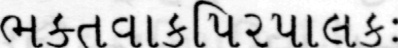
ભક્તવાકપિરપાલકઃ
